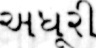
અધૂરી
